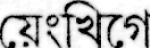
য়েংখিগে
